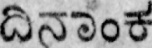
ದಿನಾಂಕ
